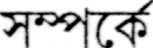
সম্পর্কে
